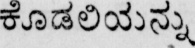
ಕೊಡಲಿಯನ್ನು
